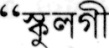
“স্কুলগী
